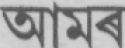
আমৰ
